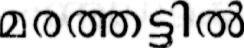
മരത്തട്ടില്‍
